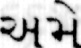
અમે
